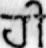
ਹੀ
